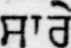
ਸਾਰੇ
